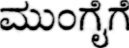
ಮುಂಗೈಗೆ
